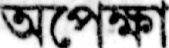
অপেক্ষা
